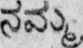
ನಮ್ಮ
